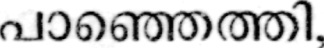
പാഞ്ഞെത്തി,
